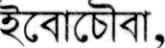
ইবোচৌবা,
